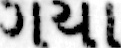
ગયા
